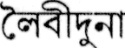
লৈবীদুনা
